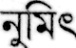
নুমিৎ
